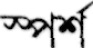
স্পর্শ
